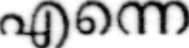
എന്നെ
